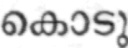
കൊടു
